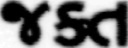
જક્ત
